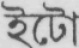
ইটো
